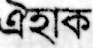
ঐহাক
